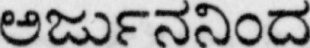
ಅರ್ಜುನನಿಂದ
